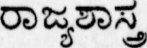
ರಾಜ್ಯಶಾಸ್ತ್ರ
